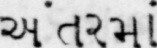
અંતરમાં
